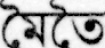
মৈতৈ
